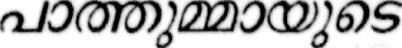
പാത്തുമ്മായുടെ
